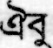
ঐবু
